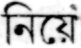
নিয়ে
